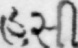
હસી
